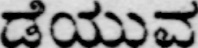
ಡೆಯುವ
